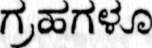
ಗ್ರಹಗಳೂ
